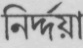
নিৰ্দ্দয়া
